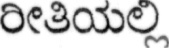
ರೀತಿಯಲ್ಲಿ
